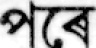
পৰে
